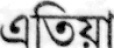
এতিয়া
